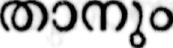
താനും
